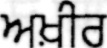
ਅਖ਼ੀਰ
